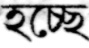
হচ্ছে
